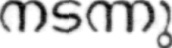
നടന്നു
